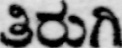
ತಿರುಗಿ
